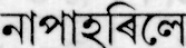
নাপাহৰিলে
